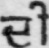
ਦੀ
